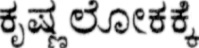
ಕೃಷ್ಣಲೋಕಕ್ಕೆ
